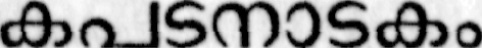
കപടനാടകം
